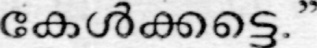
കേള്‍ക്കട്ടെ.”
